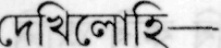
দেখিলোহি-
